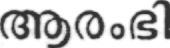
ആരംഭി
